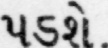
પડશે.
